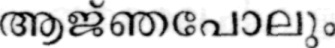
ആജ്ഞപോലും
